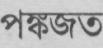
পঙ্কজত
